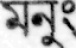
মনুং
